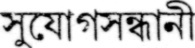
সুযোগসন্ধানী
